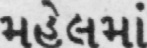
મહેલમાં
